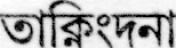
তাক্নিংদনা
